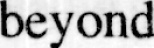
beyond
